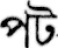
পট
